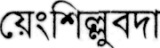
য়েংশিল্লুবদা
